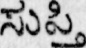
ಸುಪ್ತಿ
